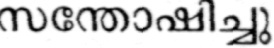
സന്തോഷിച്ചു
